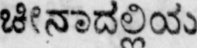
ಚೀನಾದಲ್ಲಿಯ
